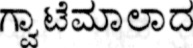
ಗ್ವಾಟೆಮಾಲಾದ
